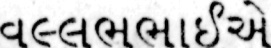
વલ્લભભાઈએ
